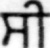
ਸੀ
